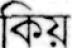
কিয়
